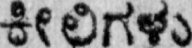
ಕೀಲಿಗಳು
